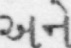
અને
